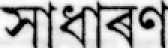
সাধাৰণ
